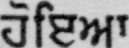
ਹੋਇਆ
